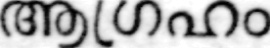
ആഗ്രഹം
